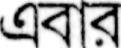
এবার
